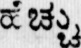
ಹೆಚ್ಚು
